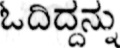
ಓದಿದ್ದನ್ನು
